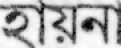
হায়না
